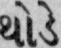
થોડે
